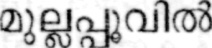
മുല്ലപ്പൂവില്‍
